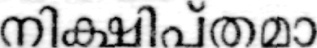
നിക്ഷിപ്തമാ
